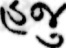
હજુ
